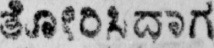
ತೋರಿಸಿದಾಗ
